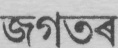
জগতৰ
